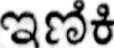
ಇಣಿಕಿ
